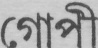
গোপী
